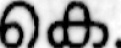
കെ.
